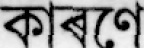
কাৰণে
